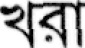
খরা
